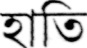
হাতি
